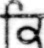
ਕਿ
